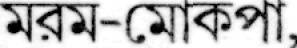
মরম-মোকপা,
